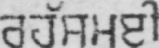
ਰਹੱਸਮਈ
